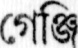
গেঞ্জি
